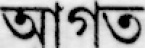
আগত
